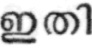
ഇതി
